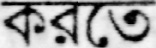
করতে
